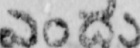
ಎಂದು
